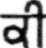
ਕੀ
